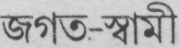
জগত-স্বামী
